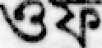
ওফ
